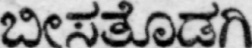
ಬೀಸತೊಡಗಿ
